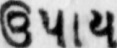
ઉપાય
